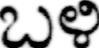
ಬಳಿ
